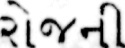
રોજની
